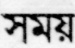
সময়
